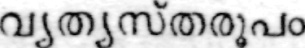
വ്യത്യസ്തരൂപം
